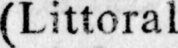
(Littoral
